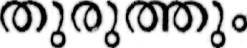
തുരുത്തും
